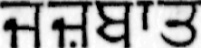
ਜਜ਼ਬਾਤ
